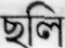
ছলি
